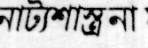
নাট্যশাস্ত্রনা
